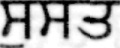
ਸੁਸਤ
